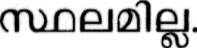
സ്ഥലമില്ല.
